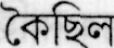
কৈছিল
